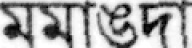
মমাঙদা
